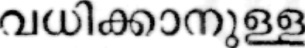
വധിക്കാനുള്ള
